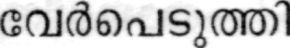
വേര്‍പെടുത്തി
